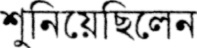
শুনিয়েছিলেন
